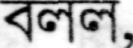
বলল,
